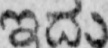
ಇದು
